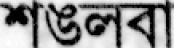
শঙলবা
